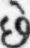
છે
